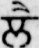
ਲੈ
